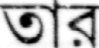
তার
